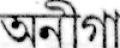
অনীগা
